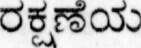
ರಕ್ಷಣೆಯ
